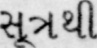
સૂત્રથી
